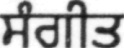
ਸੰਗੀਤ
